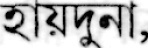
হায়দুনা,
